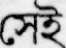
সেই
